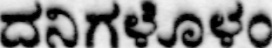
ದನಿಗಳೊಳಂ
